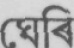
ঘেৰি
